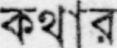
কথার
